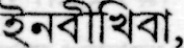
ইনবীখিবা,
